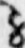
કે
